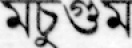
মচগুম
